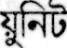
য়ুনিট
